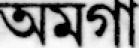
অমগা
